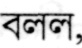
বলল,
